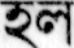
হল
